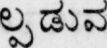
ಲ್ಪಡುವ
